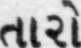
તારો
